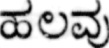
ಹಲವು
